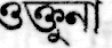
ওক্তুনা
